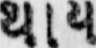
થાય
